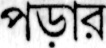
পড়ার
